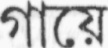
গায়ে
